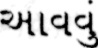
આવવું
